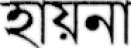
হায়না
